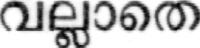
വല്ലാതെ
